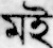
মই
